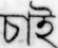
চাই
